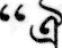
“ঐ
